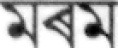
মৰম
